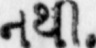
નથી.
